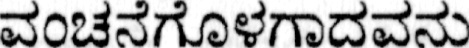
ವಂಚನೆಗೊಳಗಾದವನು
